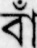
বাঁ
